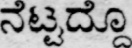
ನೆಟ್ಟದ್ದೊ
